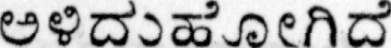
ಅಳಿದುಹೋಗಿದೆ
